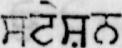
ਸਟੇਸ਼ਨ
